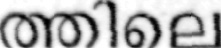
ത്തിലെ
